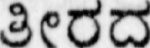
ತೀರದ
